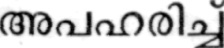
അപഹരിച്ച്
